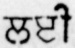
ਲਈ
